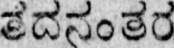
ತದನಂತರ
